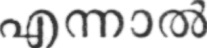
എന്നാല്‍
